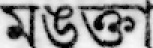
মঙক্তা
